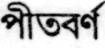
পীতবর্ণ
